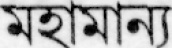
মহামান্য
